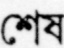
শেষ
